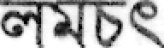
লমচৎ
